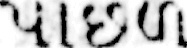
પાછળ
